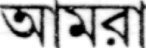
আমরা
